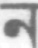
ন
